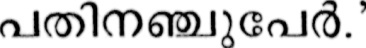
പതിനഞ്ചുപേര്‍.’
